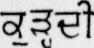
ਕੁੜ੍ਹਦੀ
